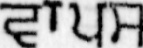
ਵਾਪਸ
